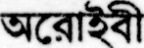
অরোইবী
